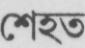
শেহত
